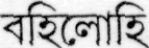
বহিলোহি
